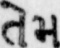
તેમ
